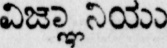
ವಿಜ್ಞಾನಿಯು
